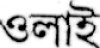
ওলাই
